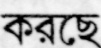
করছে
